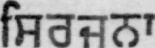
ਸਿਰਜਨਾ
